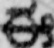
ಈ
